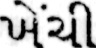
ખેંચી
